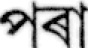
পৰা
